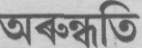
অৰুন্ধতি
